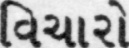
વિચારો
